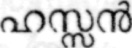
ഹസ്സന്‍
